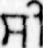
ਸੀ
